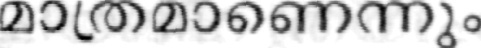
മാത്രമാണെന്നും
